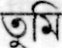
তুমি
